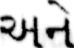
અને
